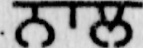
ਨਾਲ
